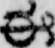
ಈ
